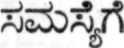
ಸಮಸ್ಯೆಗೆ
